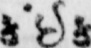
કંઈક
